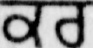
ਕਰ
